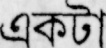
একটা
